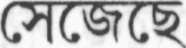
সেজেছে
